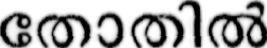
തോതില്‍
